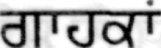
ਗਾਹਕਾਂ
